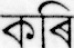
কৰি
